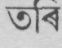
তৰি
